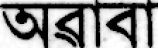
অৱাবা
